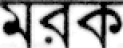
মরক
